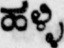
ಹಳ್ಳಿ
